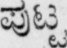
ಪುಟ್ಟ
